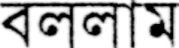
বললাম
